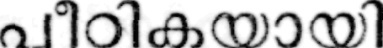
പീഠികയായി
